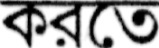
করতে
